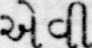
એવી
